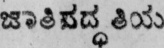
ಜಾತಿಪದ್ಧತಿಯ
